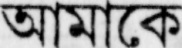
আমাকে
